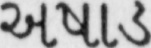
અષાડ
